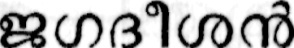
ജഗദീശന്‍
